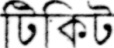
টিকিট
